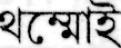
থম্মোই
